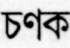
চণক
